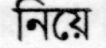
নিয়ে
